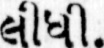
લીધી.
